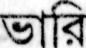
ভারি
